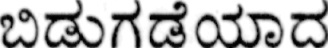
ಬಿಡುಗಡೆಯಾದ
